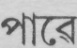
পাৱে
